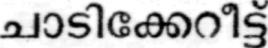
ചാടിക്കേറീട്ട്
